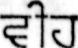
ਵੀਹ
